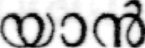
യാന്‍
